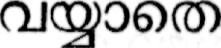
വയ്യാതെ
